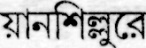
য়ানশিল্লুরে
